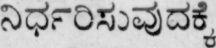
ನಿರ್ಧರಿಸುವುದಕ್ಕೆ
